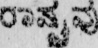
ರಾಷ್ಟ್ರವು
